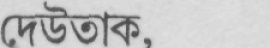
দেউতাক,
